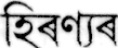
হিৰণ্যৰ
